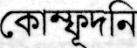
কোম্ফূদনি
